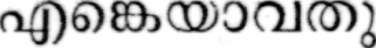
എങ്കെയാവതു
